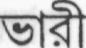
ভারী
